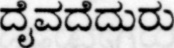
ದೈವದೆದುರು
